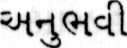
અનુભવી
